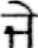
ਜੇ
